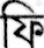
ফি
